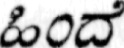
ಹಿಂದೆ
